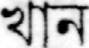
খান
